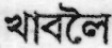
খাবলৈ
